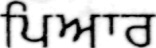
ਪਿਆਰ
